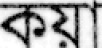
কয়া
